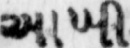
આખી
